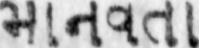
માનવતા
